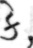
કે,
